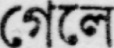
গেলে
